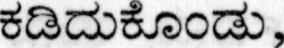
ಕಡಿದುಕೊಂಡು,
